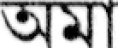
অমা
